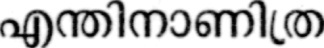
എന്തിനാണിത്ര
